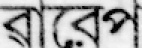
ৱারেপ
